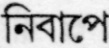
নিবাপে
